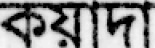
কয়াদা
